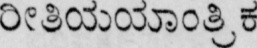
ರೀತಿಯಯಾಂತ್ರಿಕ
